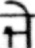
ਜੇ
